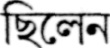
ছিলেন
